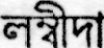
লম্বীদা
